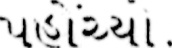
પહોંચ્યો.
